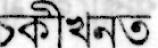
চকীখনত
